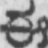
ಈ
